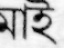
মাই
